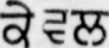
ਕੇਵਲ
